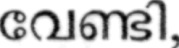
വേണ്ടി,
